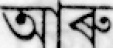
আৰু
